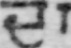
ਦਾ
